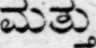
ಮತ್ತು
